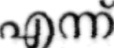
എന്ന്
